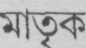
মাতৃক
